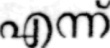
എന്ന്
